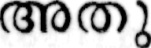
അതു
